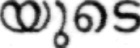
യുടെ
